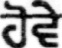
ਹੋਵੇ
